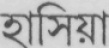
হাসিয়া
